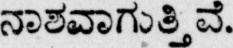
ನಾಶವಾಗುತ್ತಿವೆ.
